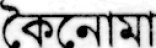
কৈনোমা
